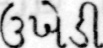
ઉખેડી
